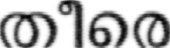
തീരെ
